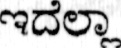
ಇದೆಲ್ಲಾ
